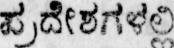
ಪ್ರದೇಶಗಳಲ್ಲಿ
